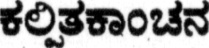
ಕಲ್ಪಿತಕಾಂಚನ
